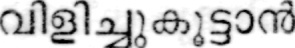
വിളിച്ചുകൂട്ടാന്‍
